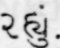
રહ્યું.
